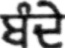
ਬੰਦੇ
